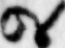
જ
